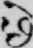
છે
